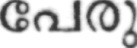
പേരു
